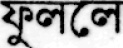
ফুললে
